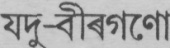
যদু-বীৰগণো
